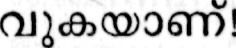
വുകയാണ്!
